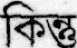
কিন্তু
